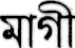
মাগী
